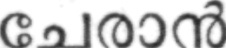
ചേരാന്‍
